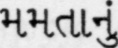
મમતાનું
